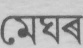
মেঘৰ
